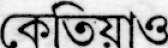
কেতিয়াও
